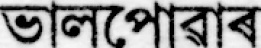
ভালপোৱাৰ
